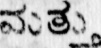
ಮತ್ತು
